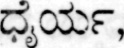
ಧೈರ್ಯ,
